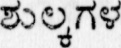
ಶುಲ್ಕಗಳ
